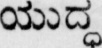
ಯುದ್ಧ
